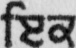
ਇਕ
